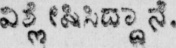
ವಿಶ್ಲೇಷಿಸಿದ್ದಾನೆ.
